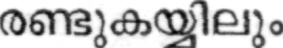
രണ്ടുകയ്യിലും
